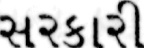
સરકારી
